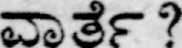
ವಾರ್ತೆ?
